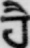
ਹੈ
